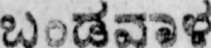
ಬಂಡವಾಳ
